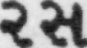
રસ
